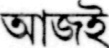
আজই
